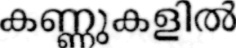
കണ്ണുകളില്‍
